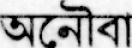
অনৌবা
